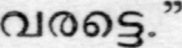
വരട്ടെ.”
